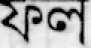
ফল
